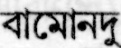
বামোনদু
